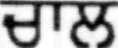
ਚਾਲ
